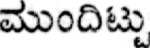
ಮುಂದಿಟ್ಟು
